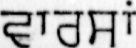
ਵਾਰਸਾਂ
